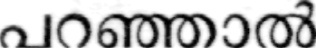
പറഞ്ഞാല്‍
